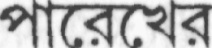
পারেখের
